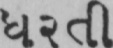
ધરતી
